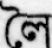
লৈ
